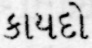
કાયદો
